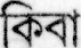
কিবা
